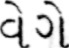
વેગે
